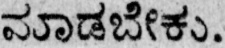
ಮಾಡಬೇಕು.
